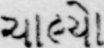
ચાલ્યો
